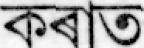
কৰাত
